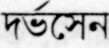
দর্ভসেন
